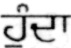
ਹੁੰਦਾ
